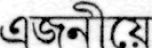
এজনীয়ে
